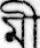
মী
